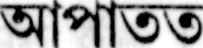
আপাতত
